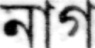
নাগ
